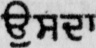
ਉਸਦਾ
